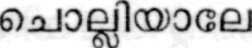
ചൊല്ലിയാലേ
